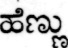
ಹೆಣ್ಣು
